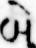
બે
